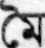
মৈ
